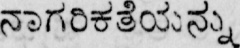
ನಾಗರಿಕತೆಯನ್ನು
